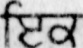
ਇਕ
